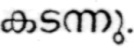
കടന്നു.
